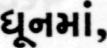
ધૂનમાં,
